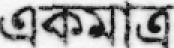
একমাত্ৰ
